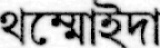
থম্মোইদা
